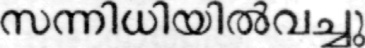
സന്നിധിയില്‍വച്ചു
